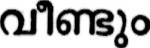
വീണ്ടും
